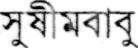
সুষীমবাবু
